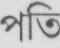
পতি
